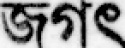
জগৎ
